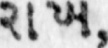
રાખ,
